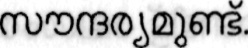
സൌന്ദര്യമുണ്ട്.
